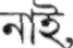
নাই,
